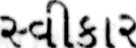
સ્વીકાર
